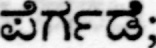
ಪೆರ್ಗಡೆ;
